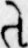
તે
